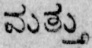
ಮತ್ತು
